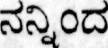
ನನ್ನಿಂದ
